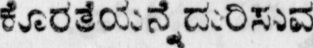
ಕೊರತೆಯನ್ನೆದುರಿಸುವ
